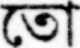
তো
